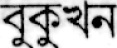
বুকুখন
